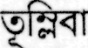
তূম্লিবা
